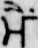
ਮੈਂ
